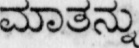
ಮಾತನ್ನು
